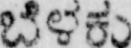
ಬೆಳಕು
